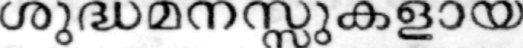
ശുദ്ധമനസ്സുകളായ
